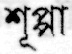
শূপ্পা
